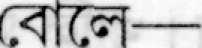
বোলে-
